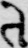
તે
